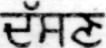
ਦੱਸਣ
